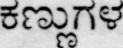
ಕಣ್ಣುಗಳ
